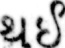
થઈ
